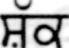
ਸ਼ੱਕ
